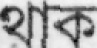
থাক
